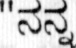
“ನನ್ನ
